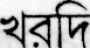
খরদি
